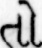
તો
